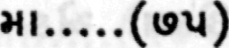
મા.....(૭૫)
